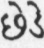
છેડે
